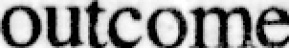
outcome
